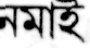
নমাই
